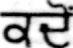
ਕਦੋਂ
